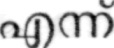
എന്ന്
